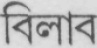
বিলাব
